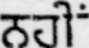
ਨਹੀਂ
